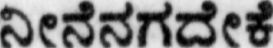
ನೀನೆನಗದೇಕೆ
